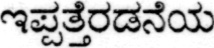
ಇಪ್ಪತ್ತೆರಡನೆಯ
